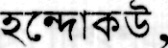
হন্দোকউ,
